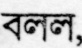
বলল,
